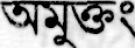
অমুক্তং
